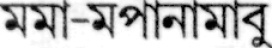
মমা-মপানামাবু
